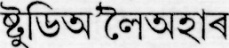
ষ্টুডিঅ'লৈঅহাৰ
